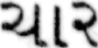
ચાર
